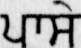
ਪਾਸੇ
